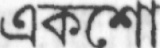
একশো
